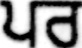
ਪਰ
